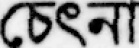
চেৎনা
